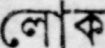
লোক
